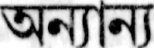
অন্যান্য
